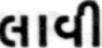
લાવી
